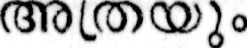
അത്രയും
